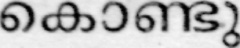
കൊണ്ടു
